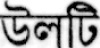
উলটি
